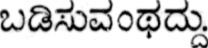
ಬಡಿಸುವಂಥದ್ದು.
